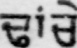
ਢਾਂਚੇ
